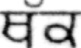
ਥੱਕ
